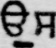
ਉਸ
